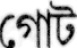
গোট
